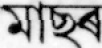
মাছৰ
